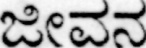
ಜೀವನ
